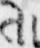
તો
